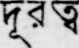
দূরত্ব
